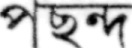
পছন্দ
